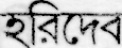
হরিদেব
